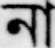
না
